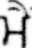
ਮੈਂ
